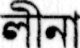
লীনা
